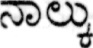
ನಾಲ್ಕು
